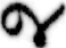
જ
